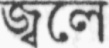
জ্বলে
